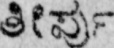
ತೀರ್ಪು
